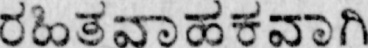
ರಹಿತವಾಹಕವಾಗಿ
